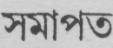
সমাপত
